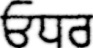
ਓਧਰ
